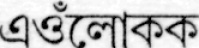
এওঁলোকক
